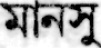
মানসু
